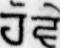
ਹੋਵੇ
